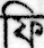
ফি
